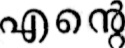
എന്റെ
